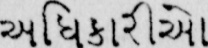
અધિકારીઓ
